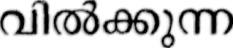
വില്‍ക്കുന്ന
